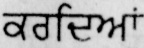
ਕਰਦਿਆਂ
